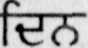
ਦਿਨ
